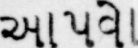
આપવો
